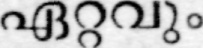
ഏറ്റവും
